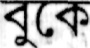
বুকে
